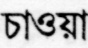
চাওয়া
